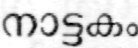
നാട്ടകം
